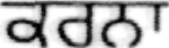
ਕਰਨਾ
